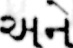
અને
